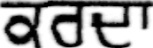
ਕਰਦਾ
